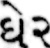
ઘેર
